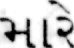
મારે
